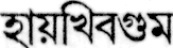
হায়খিবগুম
